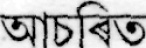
আচৰিত
